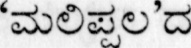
‘ಮಲಿಪ್ಪಲ’ದ
